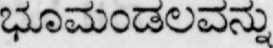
ಭೂಮಂಡಲವನ್ನು
